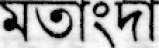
মতাংদা
